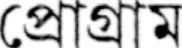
প্রোগ্রাম
